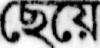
ছেয়ে
